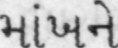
માંખને
